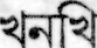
খনখি
